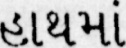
હાથમાં
